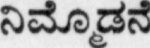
ನಿಮ್ಮೊಡನೆ
